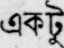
একটু
